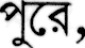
পুরে,
